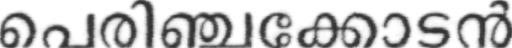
പെരിഞ്ചക്കോടന്‍
